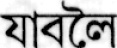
যাবলৈ
